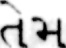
તેમ
